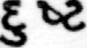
દુષ્ટ
